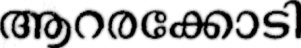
ആറരക്കോടി
